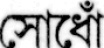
সোধোঁ
